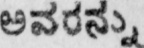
ಅವರನ್ನು
